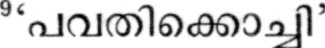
9'പവതിക്കൊച്ചി'
